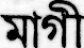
মাগী
